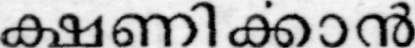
ക്ഷണിക്കാന്‍
